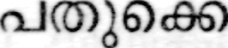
പതുക്കെ
